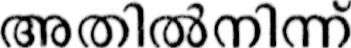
അതില്‍നിന്ന്
